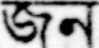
জন
